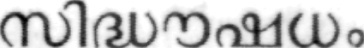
സിദ്ധൌഷധം
